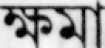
ক্ষমা
